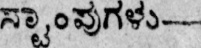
ಸ್ಟಾಂಪುಗಳು-
